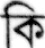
কি
